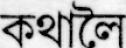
কথালৈ
